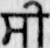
ਸੀ
